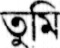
তুমি
